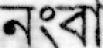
নংবা
